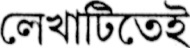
লেখাটিতেই
